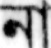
না
